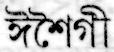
ঈশৈগী
